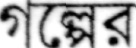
গল্পের
